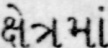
ક્ષેત્રમાં
